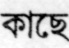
কাছে
